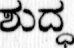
ಶುದ್ಧ
